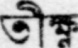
তীক্ষ্ন
